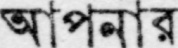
আপনার
